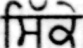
ਸਿੱਕੇ
